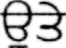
ਉਤੇ
